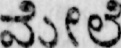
ಮೇಲೆ
